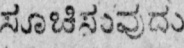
ಸೂಚಿಸುವುದು
